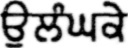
ਉਲੰਘਕੇ
